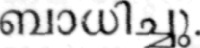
ബാധിച്ചു.
